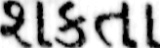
શકતા
